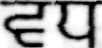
ਵਧ
